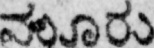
ಮೂರು
